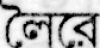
লৈরে
